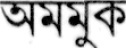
অমমুক
